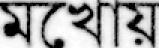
মখোয়
